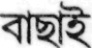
বাছাই
